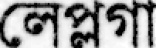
লেপ্লগা
